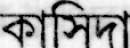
কাসিদা
